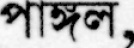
পাঙ্গল,
